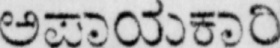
ಅಪಾಯಕಾರಿ
